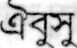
ঐবুসু
